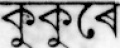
কুকুৰে
